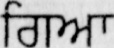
ਗਿਆ
